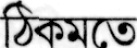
ঠিকমতে
